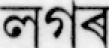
লগৰ
